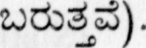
ಬರುತ್ತವೆ).
